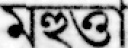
মহুত্তা
